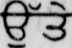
ਉੱਤੇ
